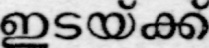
ഇടയ്ക്ക്
